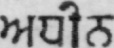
ਅਧੀਨ
